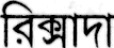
রিক্সাদা
